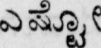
ಎಷ್ಟೋ
